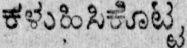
ಕಳುಹಿಸಿಕೊಟ್ಟ
